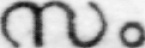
സം
